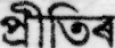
প্রীতিৰ
